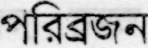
পরিব্রজন
